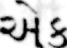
એક
